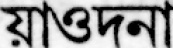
য়াওদনা
